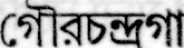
গৌরচন্দ্রগা
